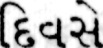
દિવસે
